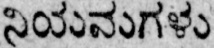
ನಿಯಮಗಳು
